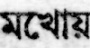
মখোয়
